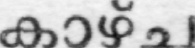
കാഴ്ച
